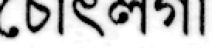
চোৎলগা
